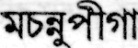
মচন্নুপীগা
